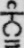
ਨੂੰ
